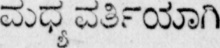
ಮಧ್ಯವರ್ತಿಯಾಗಿ
